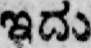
ಇದು
